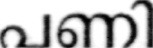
പണി
